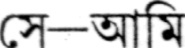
সে–আমি
